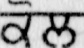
ਕੋਲ
